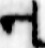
ન
